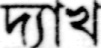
দ্যাখ
